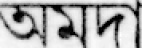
অমদা
